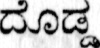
ದೊಡ್ಡ
